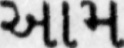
આમ
